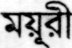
ময়ূরী
